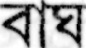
বাঘ
